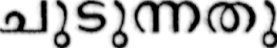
ചുടുന്നതു
